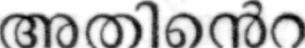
അതിന്റെ
